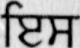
ਇਸ
